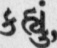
કહ્યું,
